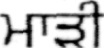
ਮਾੜੀ
